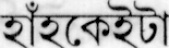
হাঁহকেইটা
